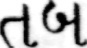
તબ
